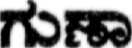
ಗುಣಾ
